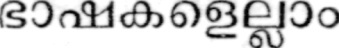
ഭാഷകളെല്ലാം
